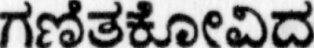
ಗಣಿತಕೋವಿದ
